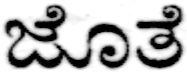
ಜೊತೆ
